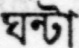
ঘন্টা
